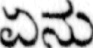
ಏನು
